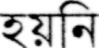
হয়নি
